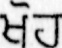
ਖੋਹ
